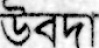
উবদা
